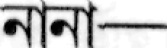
নানা-
